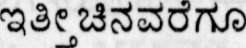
ಇತ್ತೀಚಿನವರೆಗೂ
